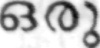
ഒരു
